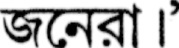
জনেরা।'
